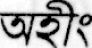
অহীং
